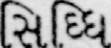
સિધ્ધિ
